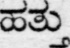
ಹತ್ತು
